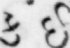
કંઈ
